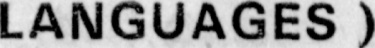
LANGUAGES)
